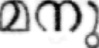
മനു
